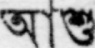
আশু
